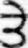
ਤੇ
